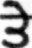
ਤੇ
